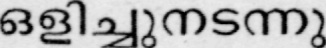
ഒളിച്ചുനടന്നു
